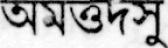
অমত্তদসু
